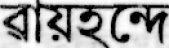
ৱায়হন্দে
